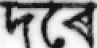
দৰে
